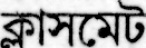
ক্লাসমেট
